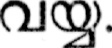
വയ്യ.
